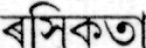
ৰসিকতা
